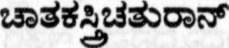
ಚಾತಕಸ್ತ್ರಿಚತುರಾನ್
